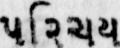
પરિચય
